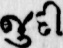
જુદી
